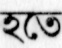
হতে
